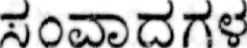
ಸಂವಾದಗಳ
